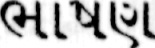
ભાષણ
